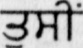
ਤੁਸੀਂ
